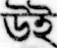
উই
